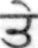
ਤੇ
